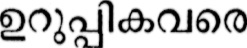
ഉറുപ്പികവരെ
